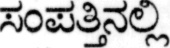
ಸಂಪತ್ತಿನಲ್ಲಿ
